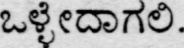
ಒಳ್ಳೇದಾಗಲಿ.
